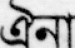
ঐনা
